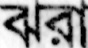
ঝরা
